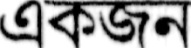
একজন
